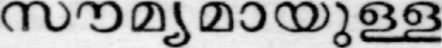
സൌമ്യമായുള്ള
